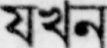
যখন
